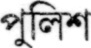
পুলিশ
